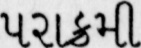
પરાક્રમી
